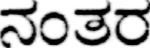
ನಂತರ
